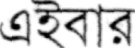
এইবার
